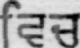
ਵਿਚ
